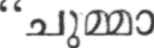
"ചുമ്മാ
